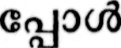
പ്പോള്‍
